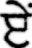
ਏਂ
